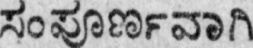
ಸಂಪೂರ್ಣವಾಗಿ
